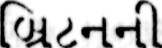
બ્રિટનની
